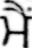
ਮੈਂ
